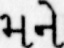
મને
